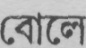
বোলে
